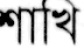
শাখি
